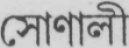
সোণালী
